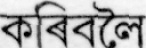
কৰিবলৈ
